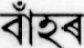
বাঁহৰ
